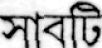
সাবটি
